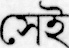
সেই
